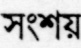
সংশয়
